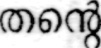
തന്റെ
